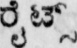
ರೈಟ್ಸ್
